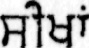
ਸੀਖਾਂ
